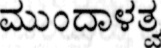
ಮುಂದಾಳತ್ವ
